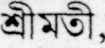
শ্রীমতী,
